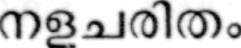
നളചരിതം
